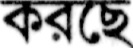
করছে
